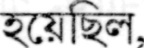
হয়েছিল,
